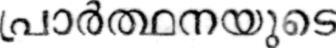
പ്രാര്‍ത്ഥനയുടെ
